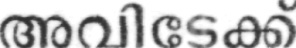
അവിടേക്ക്
